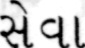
સેવા
